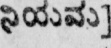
ನಿಯಮ]
